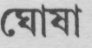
ঘোষা
